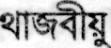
থাজবীয়ু
